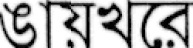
ঙায়খরে
